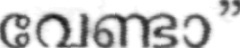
വേണ്ടാ”
